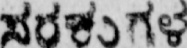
ಸರಕುಗಳ
